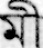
মী
